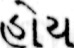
હોય
